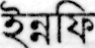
ইন্নফি
